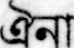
ঐনা
